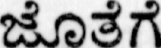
ಜೊತೆಗೆ
